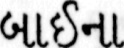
બાઈના
